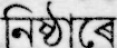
নিষ্ঠাৰে
